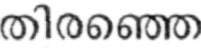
തിരഞ്ഞെ
